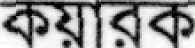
কয়ারক
